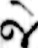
જે
